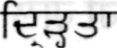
ਦ੍ਰਿੜ੍ਹਤਾ
